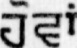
ਹੋਵਾਂ
